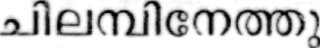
ചിലമ്പിനേത്തു
